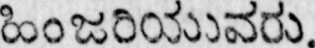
ಹಿಂಜರಿಯುವರು.
